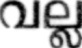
വല്ല
